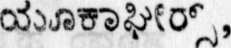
ಯೂಕಾಘೀರ್‍ಸ್,
